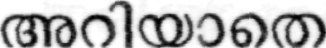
അറിയാതെ
